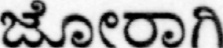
ಜೋರಾಗಿ
